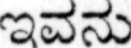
ಇವನು
